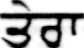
ਤੇਰਾ
